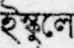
ইস্কুলে
